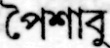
পৈশাদু
